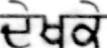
ਦੇਖਕੇ
